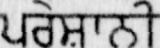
ਪਰੇਸ਼ਾਨੀ
